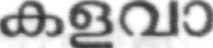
കളവാ
